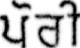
ਪੋਰੀ
